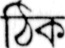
ঠিক
